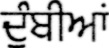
ਦੁੰਬੀਆਂ
